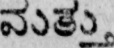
ಮತ್ತು
